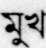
মুখ
